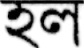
হল
